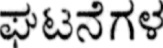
ಘಟನೆಗಳ
